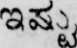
ಇಷ್ಟು
